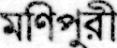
মণিপুরী
